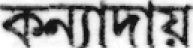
কন্যাদায়
